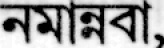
নমান্নবা,
